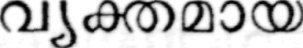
വ്യക്തമായ
